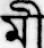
মী
